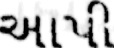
આપી
